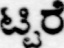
ಟ್ಟಿರೆ
